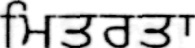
ਮਿਤਰਤਾ
